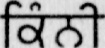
ਕਿੰਨੀ
